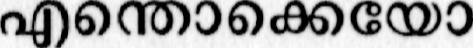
എന്തൊക്കെയോ
